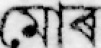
মোৰ
